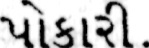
પોકારી.
